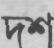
দশ
